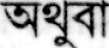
অথুবা
